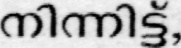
നിന്നിട്ട്,
